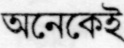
অনেকেই
